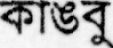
কাঙবু
